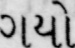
ગયો
